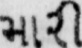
મારી
